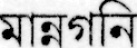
মান্নগনি
